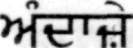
ਅੰਦਾਜ਼ੇ
